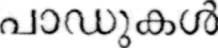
പാഡുകള്‍
